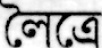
লৈত্রে
